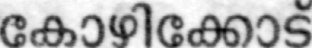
കോഴിക്കോട്
